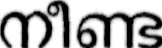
നീണ്ട
